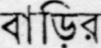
বাড়ির
